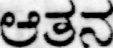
ಆತನ
